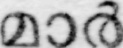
മാര്‍
